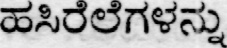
ಹಸಿರೆಲೆಗಳನ್ನು
